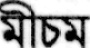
মীচম
